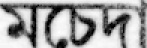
মচেদা
